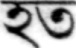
হত
